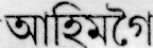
আহিমগৈ
